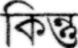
কিন্তু
